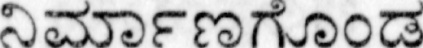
ನಿರ್ಮಾಣಗೊಂಡ
